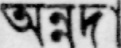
অন্নদা
